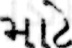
માટે
